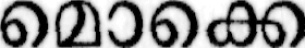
മൊക്കെ
